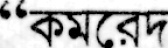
“কমরেদ
